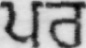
ਪਰ
